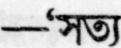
–‘সত্য
